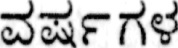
ವರ್ಷಗಳ
